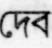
দেব
